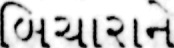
બિચારાને
